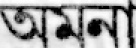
অমনা
